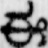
ಈ
